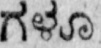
ಗಳೂ
